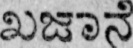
ಖಜಾನೆ
